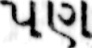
પણ
